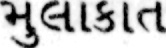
મુલાકાત
